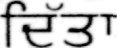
ਦਿੱਤਾ
